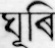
ঘূৰি
